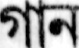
গান
